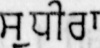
ਸੁਧੀਰਾ
